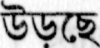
উড়ছে
